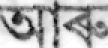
আৰু
